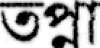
তপ্না
